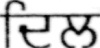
ਦਿਲ
